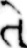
તે
